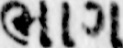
ભાગ
